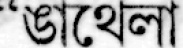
“ঙাথেলা
